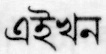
এইখন
